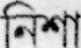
নিশা
